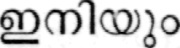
ഇനിയും
